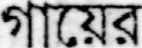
গায়ের
